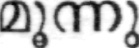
മൂന്നു
